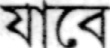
যাবে
